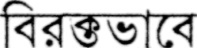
বিরক্তভাবে
